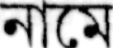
নামে
